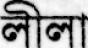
লীলা
